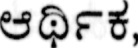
ಆರ್ಥಿಕ,
